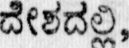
ದೇಶದಲ್ಲಿ,
